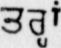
ਤਰ੍ਹਾਂ
